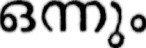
ഒന്നും
